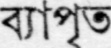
ব্যাপৃত
